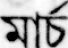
মার্চ
